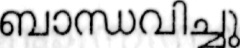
ബാന്ധവിച്ചു
